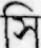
সি
